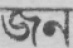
জন
